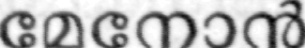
മേനോന്‍
